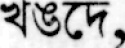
খঙদে,
